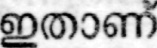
ഇതാണ്
